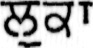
ਲੁਕਾ
